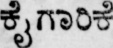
ಕೈಗಾರಿಕೆ
